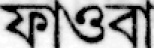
ফাওবা
